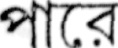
পারে
